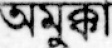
অমুক্কা
